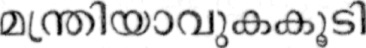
മന്ത്രിയാവുകകൂടി
